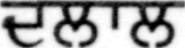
ਦਲਾਲ
